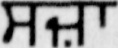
ਸਜ਼ਾ
